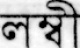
লম্বী
